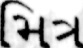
મિત્ર
